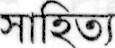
সাহিত্য
